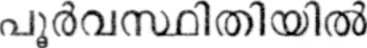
പൂര്‍വസ്ഥിതിയില്‍
